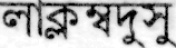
লাক্লম্বদুসু
